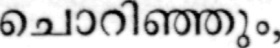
ചൊറിഞ്ഞും,
